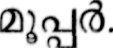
മൂപ്പര്‍.
